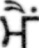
ਮੈਂ
